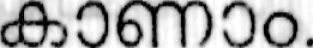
കാണാം.
